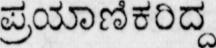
ಪ್ರಯಾಣಿಕರಿದ್ದ
